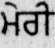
ਮੇਰੀ
